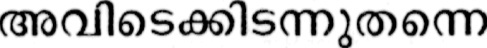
അവിടെക്കിടന്നുതന്നെ
